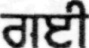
ਗਈ
